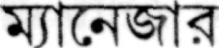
ম্যানেজার
